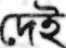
দেই
